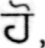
ਹੋ,
